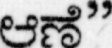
ಆಣೆ”
